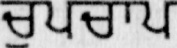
ਚੁਪਚਾਪ
